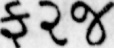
ફરજ
